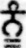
ਨੂੰ
